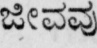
ಜೀವವು
